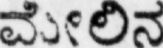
ಮೇಲಿನ
